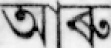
আৰু
